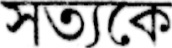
সত্যকে
